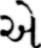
એ
